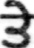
ਤੇ
